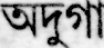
অদুগা
